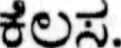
ಕೆಲಸ.
